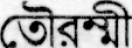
তৌরম্মী
